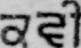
ਕਵੀ
